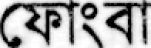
ফোংবা
